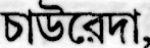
চাউরেদা,
